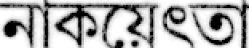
নাকয়েৎতা
